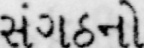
સંગઠનો
